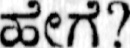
ಹೇಗೆ?
